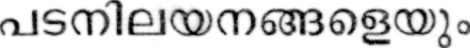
പടനിലയനങ്ങളെയും
